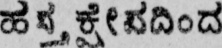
ಹಸ್ತಕ್ಷೇಪದಿಂದ
